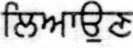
ਲਿਆਉਣ
